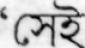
'সেই
